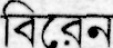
বিরেন
